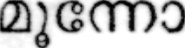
മൂന്നോ
